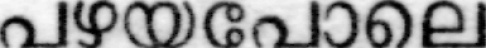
പഴയപോലെ
